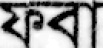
ফবা
